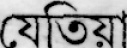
যেতিয়া
